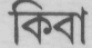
কিবা
